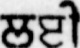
ਲਈ
